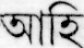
আহি
